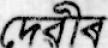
দেৱীৰ
